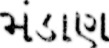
મંડાણ
